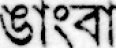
ঙাংবা
